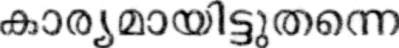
കാര്യമായിട്ടുതന്നെ
